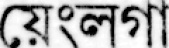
য়েংলগা
